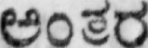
ಅಂತರ
